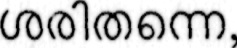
ശരിതന്നെ,
